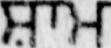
ਸ਼ਾਮ
